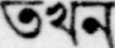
তখন
